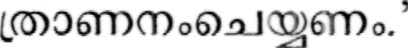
ത്രാണനംചെയ്യണം.'
